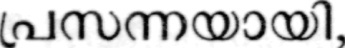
പ്രസന്നയായി,
